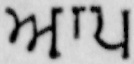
ਆਪ
